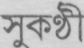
সুকণ্ঠী
